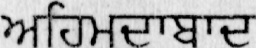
ਅਹਿਮਦਾਬਾਦ
